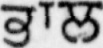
ਭਾਲ
